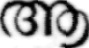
ആ
